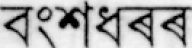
বংশধৰৰ
